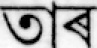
তাৰ
